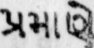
પ્રમાણે
